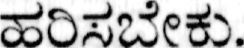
ಹರಿಸಬೇಕು.
